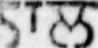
ਨਾਲ
